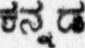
ಕನ್ನಡ
